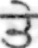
ਤੇ
